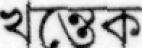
খন্তেক
